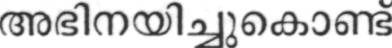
അഭിനയിച്ചുകൊണ്ട്
